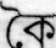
কৈ
